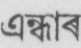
এন্ধাৰ
